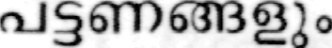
പട്ടണങ്ങളും
